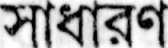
সাধারণ
